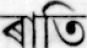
ৰাতি
